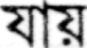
যায়
